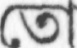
তো
